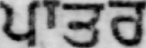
ਪਾਤਰ
